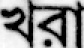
খরা
